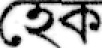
হেক
